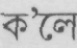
ক'লে
